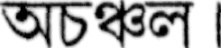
অচঞ্চল।
